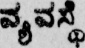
ವ್ಯವಸ್ಥೆ
